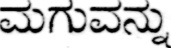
ಮಗುವನ್ನು
